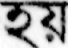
হয়
